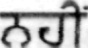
ਨਹੀਂ
